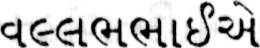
વલ્લભભાઈએ
